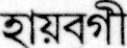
হায়বগী
